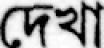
দেখা
